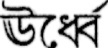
ঊর্ধ্বে
